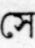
সে
